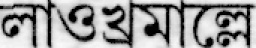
লাওখ্রমাল্লে
